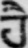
ਹੈ
